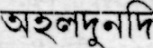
অহলদুনদি
